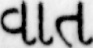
વાત
